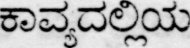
ಕಾವ್ಯದಲ್ಲಿಯ
